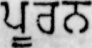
ਪੂਰਨ
